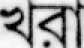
খরা
